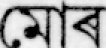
মোৰ
